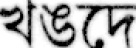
খঙদে
